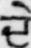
ਦੇ
